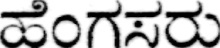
ಹೆಂಗಸರು
